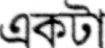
একটা
